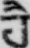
ਹੈ
